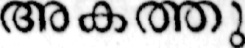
അകത്തു
